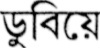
ডুবিয়ে
